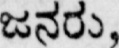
ಜನರು,
